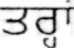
ਤਰ੍ਹਾਂ
